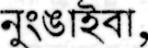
নুংঙাইবা,
